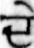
ਦੇ
